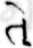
તે
